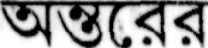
অন্তরের
